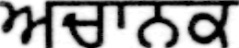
ਅਚਾਨਕ
